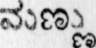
ಮಣ್ಣು
